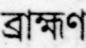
ব্রাহ্মণ
